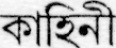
কাহিনী
